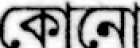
কোনো
